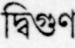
দ্বিগুণ
